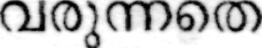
വരുന്നതെ
